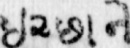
ઇચ્છાને
